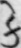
કે
